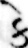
કે
